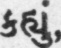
કહ્યું,
